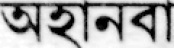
অহানবা
